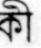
কী
